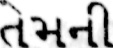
તેમની
